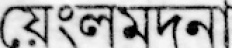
য়েংলমদনা
